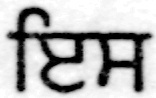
ਇਸ
